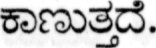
ಕಾಣುತ್ತದೆ.
